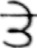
ਤੇ
